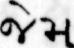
જેમ
